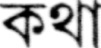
কথা
